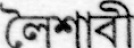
লৈশাবী
